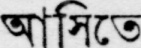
আসিতে
